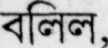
বলিল,
